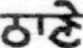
ਠਾਣੇ
